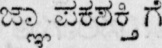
ಜ್ಞಾಪಕಶಕ್ತಿಗೆ
